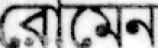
রোমেন
